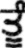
ਤੂੰ
